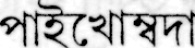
পাইখোম্বদা
